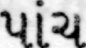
પાંચ
